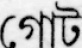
গোট
